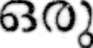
ഒരു
